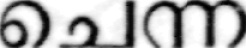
ചെന്ന
